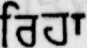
ਰਿਹਾ
